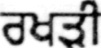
ਰਖੜੀ
